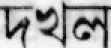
দখল
